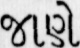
જાણે
